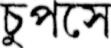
চুপসে
